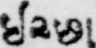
ઇચ્છા
